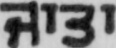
ਜਾਤਾ
